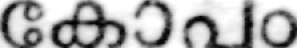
കോപം
